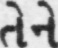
તેને
